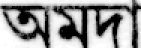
অমদা
